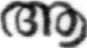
ആ
